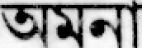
অমনা
